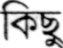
কিছু
